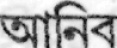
আনিব
